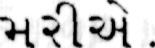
મરીએ.
